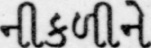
નીકળીને
